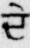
ਦੇ
